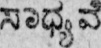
ಸಾಧ್ಯವೆ
